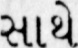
સાથે
